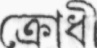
ক্রোধী
